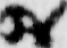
જ
